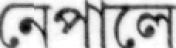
নেপালে
